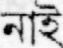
নাই
